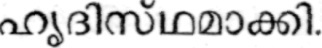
ഹൃദിസ്ഥമാക്കി.
